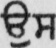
ਉਸ
